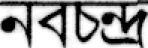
নবচন্দ্র
